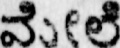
ಮೇಲೆ
